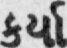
કર્યા
